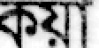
কয়া
